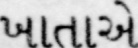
ખાતાએ
